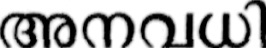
അനവധി
